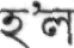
হ'ল
